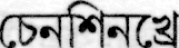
চেনশিনখ্রে
